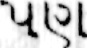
પણ
